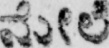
ಮೇಲೆ
